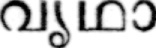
വൃഥാ
